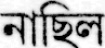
নাছিল
